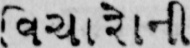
વિચારોની
